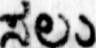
ಸಲು
